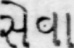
સેવા
